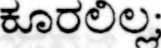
ಕೂರಲಿಲ್ಲ;
